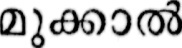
മുക്കാല്‍
